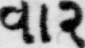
વાર
